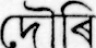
দৌৰি
